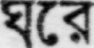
ঘরে
